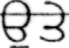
ਉਤੇ
